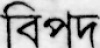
বিপদ
